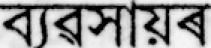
ব্যৱসায়ৰ
